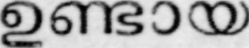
ഉണ്ടായ
